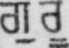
ਗੁਰੂ
